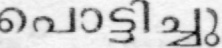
പൊട്ടിച്ചു
